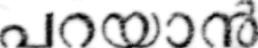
പറയാന്‍
